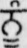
ਨੂੰ
